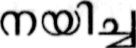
നയിച്ച
